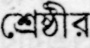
শ্রেষ্ঠীর
